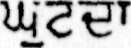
ਘੁਟਦਾ
